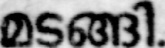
മടങ്ങി.
